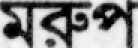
মরুপ
